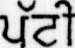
ਪੱਟੀ
